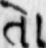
તો
